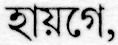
হায়গে,
